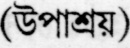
(উপাশ্রয়)
